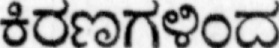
ಕಿರಣಗಳಿಂದ
